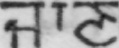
ਜਾਣ
